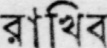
রাখিব
